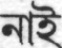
নাই
